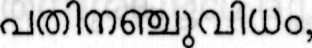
പതിനഞ്ചുവിധം,
